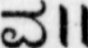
ವ||
